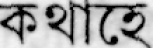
কথাহে
